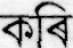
কৰি
